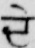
ਦੇ
